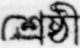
শ্রেষ্ঠী
